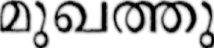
മുഖത്തു
